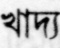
খাদ্য
